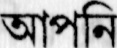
আপনি
